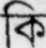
কি
